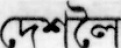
দেশলৈ
